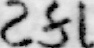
ટકા
